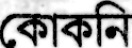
কোকনি
